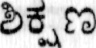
ಶಿಕ್ಷಣ
